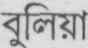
বুলিয়া
